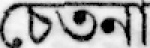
চেতনা
